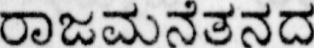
ರಾಜಮನೆತನದ
